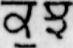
ਕੁਝ
